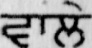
ਵਾਲੇ
